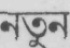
নতুন
